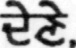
ਦੇਣੇ,
